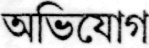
অভিযোগ
